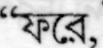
“ফরে,
